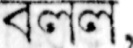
বলল,
